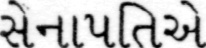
સેનાપતિએ
